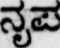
ನೃಪ
